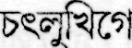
চৎলুখিগে
